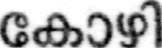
കോഴി
